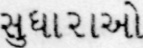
સુધારાઓ
